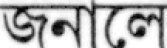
জনালে
